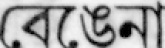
বেঙেনা
